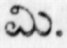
ಮಿ.
